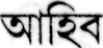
আহিব
